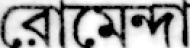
রোমেন্দা
